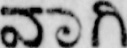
ವಾಗಿ
